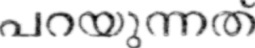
പറയുന്നത്
